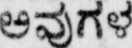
ಅವುಗಳ
